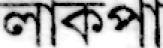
লাকপা
